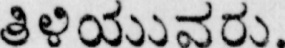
ತಿಳಿಯುವರು.
